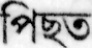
পিছত
